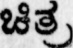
ಚಿತ್ರ
